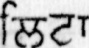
ਲਿਟਾ
